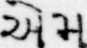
એમ
